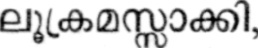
ലൂക്രമസ്സാക്കി,
